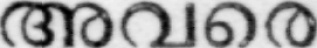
അവരെ
